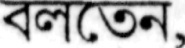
বলতেন,
